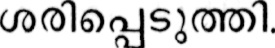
ശരിപ്പെടുത്തി.
